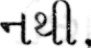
નથી,
